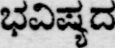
ಭವಿಪ್ಯದ
